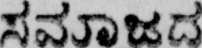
ಸಮಾಜದ
